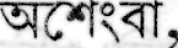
অশেংবা,
